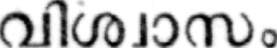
വിശ്വാസം
